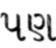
પણ
